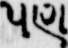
પણ
